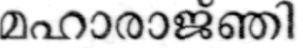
മഹാരാജ്ഞി
